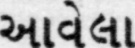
આવેલા
